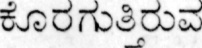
ಕೊರಗುತ್ತಿರುವ
